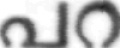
പറ
